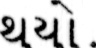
થયો.
